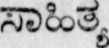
ಸಾಹಿತ್ಯ
